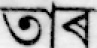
তাৰ
